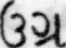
ઉગ્ર
